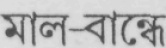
মাল-বান্ধে
